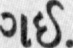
ગઈ.
